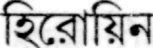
হিরোয়িন
